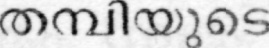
തമ്പിയുടെ
